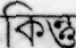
কিন্তু
